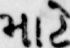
માટે
